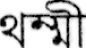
থম্মী
